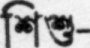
শিশু-
